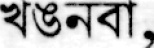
খঙনবা,
